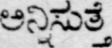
ಅನ್ನಿಸುತ್ತೆ
